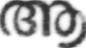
ആ
